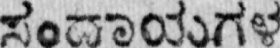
ಸಂದಾಯಗಳ
